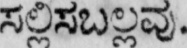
ಸಲ್ಲಿಸಬಲ್ಲವು.
